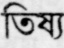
তিষ্য
